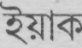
ইয়াক
